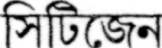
সিটিজেন
